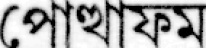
পোত্থাফম
